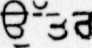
ਉੱਤਰ
